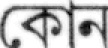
কোন
